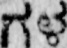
ಗಳ
